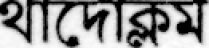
থাদোক্লম
